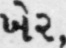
ખેર,
